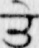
ਤੇ
